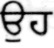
ਉਹ
